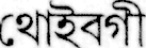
থোইবগী
